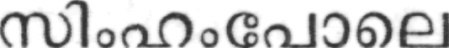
സിംഹംപോലെ
